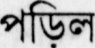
পড়িল
